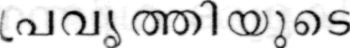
പ്രവൃത്തിയുടെ
